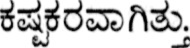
ಕಷ್ಟಕರವಾಗಿತ್ತು.
